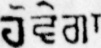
ਹੋਵੇਗਾ
